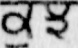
ਕੁਝ
